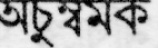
অচুম্বমক
